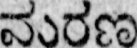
ಮರಣ
